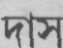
দাস
